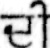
ਦੀ
